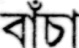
বাঁচা
